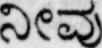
ನೀವು
